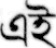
এই
